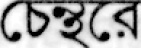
চেন্থরে
